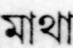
মাথা
